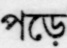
পড়ে
